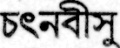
চৎনবীসু
